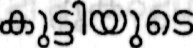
കുട്ടിയുടെ
